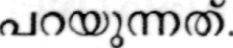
പറയുന്നത്.
